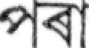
পৰা
